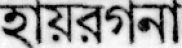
হায়রগনা
